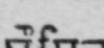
ਬੌਧਿਕ
